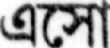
এসো
